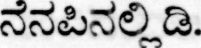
ನೆನಪಿನಲ್ಲಿಡಿ.
